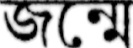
জন্মে
